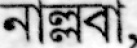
নাল্লবা,
